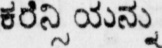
ಕರೆನ್ಸಿಯನ್ನು
